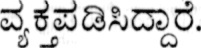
ವ್ಯಕ್ತಪಡಿಸಿದ್ದಾರೆ.
